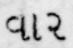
વાર
